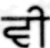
ਵੀ
